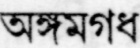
অঙ্গমগধ
